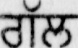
ਗੱਲ
